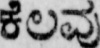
ಕೆಲವು
